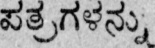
ಪತ್ರಗಳನ್ನು
